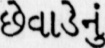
છેવાડેનું
